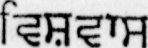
ਵਿਸ਼ਵਾਸ
